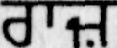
ਰਾਜ਼
